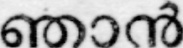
ഞാന്‍
